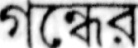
গন্ধের
